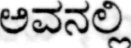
ಅವನಲ್ಲಿ
